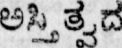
ಅಸ್ತಿತ್ವದ
